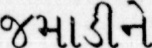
જમાડીને
